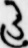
હે
